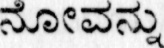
ನೋವನ್ನು
